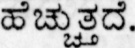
ಹೆಚ್ಚುತ್ತದೆ.
